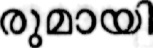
രുമായി
